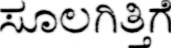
ಸೂಲಗಿತ್ತಿಗೆ
